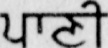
ਪਾਣੀ
